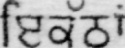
ਇਕੱਠਾਂ
